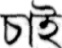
চাই
